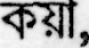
কয়া,
